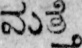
ಮತ್ತೆ
